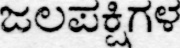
ಜಲಪಕ್ಷಿಗಳ
